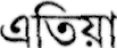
এতিয়া
